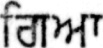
ਗਿਆ
